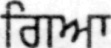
ਗਿਆ
